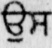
ਉਸ
